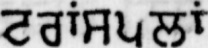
ਟਰਾਂਸਪਲਾਂ
